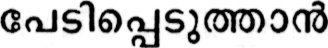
പേടിപ്പെടുത്താന്‍
